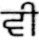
ਵੀ
